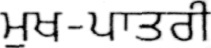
ਮੁਖ-ਪਾਤਰੀ
